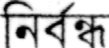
নির্বন্ধ
